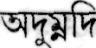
অদুম্নদি
